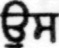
ਉਸ
